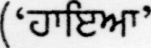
('ਹਾਇਆ'
